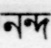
নন্দ
